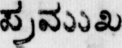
ಪ್ರಮುಖ
